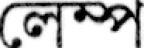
লেম্প
